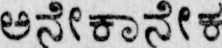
ಅನೇಕಾನೇಕ
